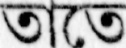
তাতে
